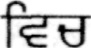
ਵਿਚ
